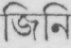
জিনি
